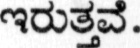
ಇರುತ್ತವೆ.
